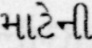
માટેની
